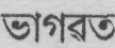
ভাগৱত
